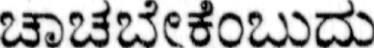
ಚಾಚಬೇಕೆಂಬುದು
